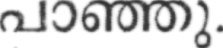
പാഞ്ഞു.
